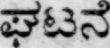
ಘಟನೆ
